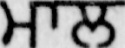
ਮਾਲ
